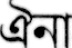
ঐনা
